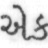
એક
